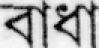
বাধা
